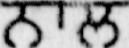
ਨਾਲ
